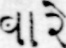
વારે
